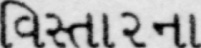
વિસ્તારના
